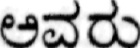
ಅವರು
